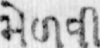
મેળવી
